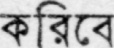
করিবে
